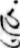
હું
